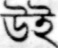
উই
